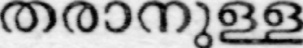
തരാനുള്ള
